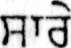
ਸਾਰੇ
